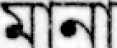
মানা
